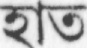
হাত
